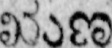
ಋಣ
